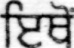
ਇਥੋਂ
